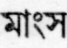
মাংস
